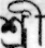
শ্রী
